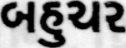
બહુચર
